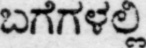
ಬಗೆಗಳಲ್ಲಿ
